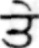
ਤੇ
